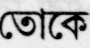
তোকে
